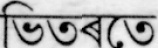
ভিতৰতে
